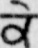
ਕੇ
